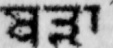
ਬੜਾ
